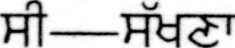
ਸੀ-ਸੱਖਣਾ
